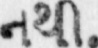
નથી,
